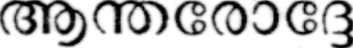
ആന്തരോദ്ദേ
